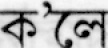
ক'লে
